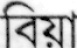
বিয়া
